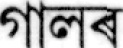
গালৰ
